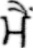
ਮੈਂ
